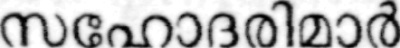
സഹോദരിമാര്‍
